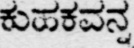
ಕುಹಕವನ್ನ
